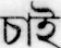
চাই
